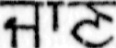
ਜਾਣ
